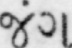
જંગ
